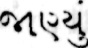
જાણ્યું
